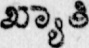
ಖ್ಯಾತಿ
